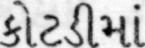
કોટડીમાં
